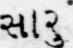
સારું
